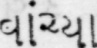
વાંચ્યા
